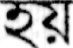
হয়
